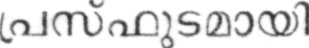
പ്രസ്ഫുടമായി
